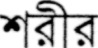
শরীর
